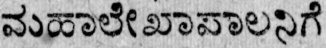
ಮಹಾಲೇಖಾಪಾಲನಿಗೆ
